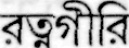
রত্নগীরি
